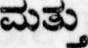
ಮತ್ತು
